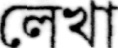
লেখা
